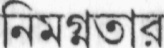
নিমগ্নতার
